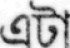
এটা
